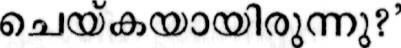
ചെയ്കയായിരുന്നു?'
